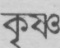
কৃষ্ণ
